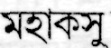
মহাকসু
